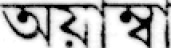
অয়াম্বা
